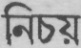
নিচয়
